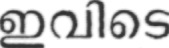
ഇവിടെ
